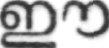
ഈ
